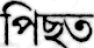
পিছত
